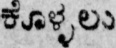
ಕೊಳ್ಳಲು
